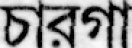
চারগা
